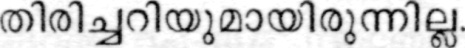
തിരിച്ചറിയുമായിരുന്നില്ല.
